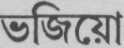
ভজিয়ো
